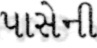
પાસેની
